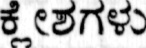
ಕ್ಲೇಶಗಳು
